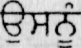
ਉਸਨੂੰ
